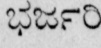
ಭರ್ಜರಿ
